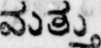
ಮತ್ತು
